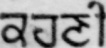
ਕਹਣੀ
